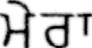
ਮੇਰਾ
